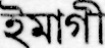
ইমাগী
